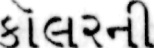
કૉલરની
